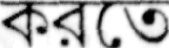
করতে
